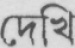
দেখি
